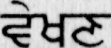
ਵੇਖਣ
